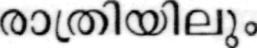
രാത്രിയിലും
